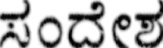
ಸಂದೇಶ
